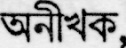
অনীখক,
